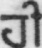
ਹੀ
